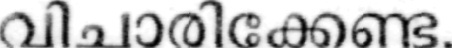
വിചാരിക്കേണ്ട.
